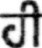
ਹੀ
